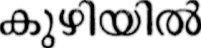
കുഴിയില്‍
